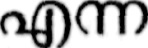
എന്ന
